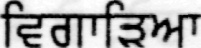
ਵਿਗਾੜਿਆ
